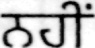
ਨਹੀਂ
